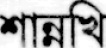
শান্নখি
